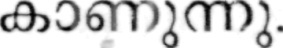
കാണുന്നു.
